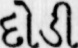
દોડી
